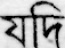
যদি
